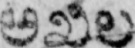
ಅಖಿಲ
